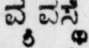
ವ್ಯವಸ್ಥೆ
